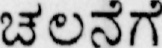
ಚಲನೆಗೆ
